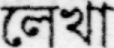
লেখা
